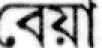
বেয়া
